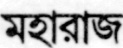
মহারাজ
